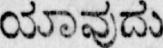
ಯಾವುದು
